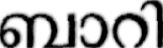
ബാറി
